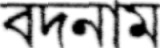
বদনাম
